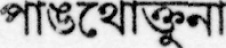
পাঙথোক্তুনা
